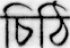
চিঠি
